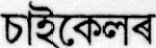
চাইকেলৰ
